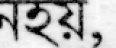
নহয়,
